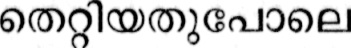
തെറ്റിയതുപോലെ
